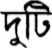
দুটি
